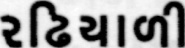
રઢિયાળી
